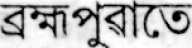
ব্রহ্মপুৱাতে
